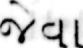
જેવા
